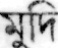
মুদি
